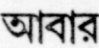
আবার
